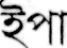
ইপা
